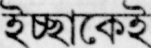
ইচ্ছাকেই
